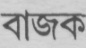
বাজক
